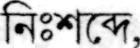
নিঃশব্দে,
